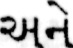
અને
